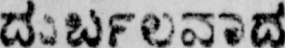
ದುರ್ಬಲವಾದ
